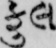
ફુલ
